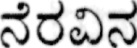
ನೆರವಿನ
